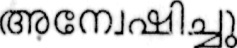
അന്വേഷിച്ചു
